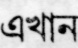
এখান
